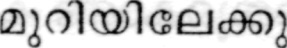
മുറിയിലേക്കു
